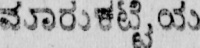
ಮಾರುಕಟ್ಟೆಯ
